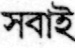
সবাই
